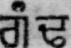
ਗੰਢ
